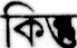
কিন্তু
